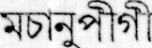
মচানুপীগী
